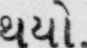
થયો.
